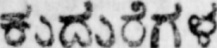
ಕುದುರೆಗಳ
